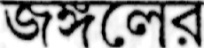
জঙ্গলের
